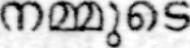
നമ്മുടെ
